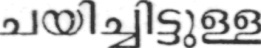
ചയിച്ചിട്ടുള്ള
